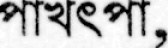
পাখৎপা,
